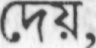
দেয়,
